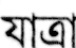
যাত্রা
